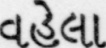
વહેલા
